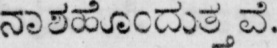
ನಾಶಹೊಂದುತ್ತವೆ.
